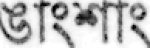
ঙাংশাং
